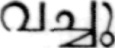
വച്ചു
